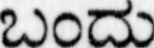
ಬಂದು
